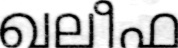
ഖലീഫ
